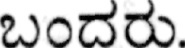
ಬಂದರು.
